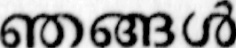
ഞങ്ങള്‍
